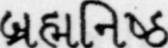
બ્રહ્મનિષ્ઠ
